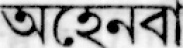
অহেনবা
